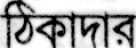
ঠিকাদার
